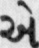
એ
